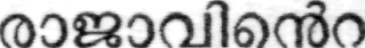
രാജാവിന്റെ
